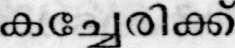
കച്ചേരിക്ക്
